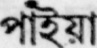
পাইয়া
